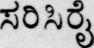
ಸರಿಸಿರೈ
